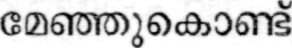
മേഞ്ഞുകൊണ്ട്
